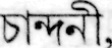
চান্দনী,
